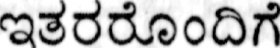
ಇತರರೊಂದಿಗೆ
